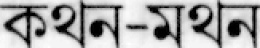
কথন-মথন
